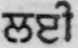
ਲਈ
